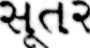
સૂતર
